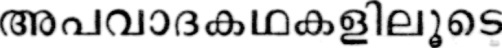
അപവാദകഥകളിലൂടെ
